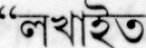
"লখাইত
